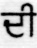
ਦੀ
